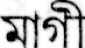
মাগী
